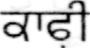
ਕਾਫ਼ੀ
